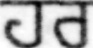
ਹਰ
